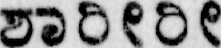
ಶಾರೀರೀ
